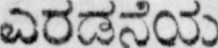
ಎರಡನೆಯ
